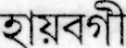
হায়বগী
